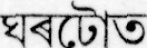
ঘৰটোত
